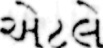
એટલે
